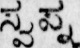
ಸ್ವಪ್ನ
